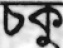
চকু
